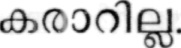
കരാറില്ല.
